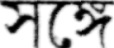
সঙ্গে
